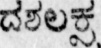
ದಶಲಕ್ಷ
